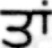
ਤਾਂ
